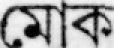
মোক
